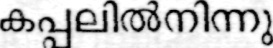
കപ്പലില്‍നിന്നു
